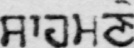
ਸਾਹਮਣੇ
